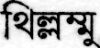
থিল্লম্মু
